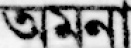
অমনা
